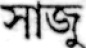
সাজু
